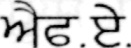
ਐਫ.ਏ.
